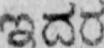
ಇದರ
